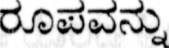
ರೂಪವನ್ನು
